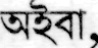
অইবা,
